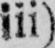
iii)
